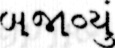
બજાવ્યું
